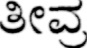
ತೀವ್ರ
